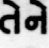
તેને
